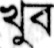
খুব
